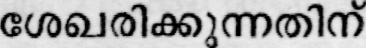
ശേഖരിക്കുന്നതിന്
